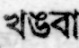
খঙবা
